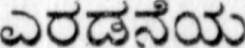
ಎರಡನೆಯ
